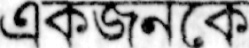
একজনকে
